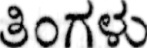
ತಿಂಗಳು
